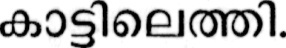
കാട്ടിലെത്തി.
